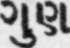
ગુણ
